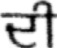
ਦੀ
